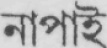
নাপাই
